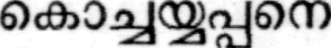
കൊച്ചയ്യപ്പനെ
